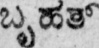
ಬೃಹತ್
